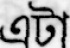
এটা
